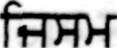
ਜਿਸਮ
